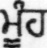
ਮੂੰਹ
